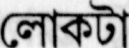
লোকটা
